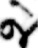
જે
